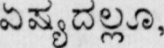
ಏಷ್ಯದಲ್ಲೂ,
